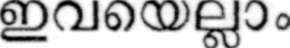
ഇവയെല്ലാം
